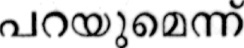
പറയുമെന്ന്
